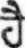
ਹੈ
